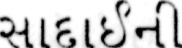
સાદાઈની
